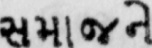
સમાજને
